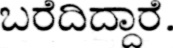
ಬರೆದಿದ್ದಾರೆ.
